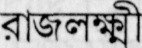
রাজলক্ষ্মী
